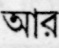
আর
